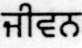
ਜੀਵਨ
